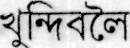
খুন্দিবলৈ
